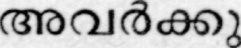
അവര്‍ക്കു
